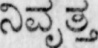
ನಿವೃತ್ತ
